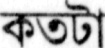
কতটা
